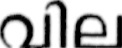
വില
